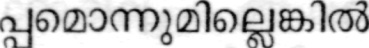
പ്പമൊന്നുമില്ലെങ്കില്‍
